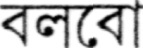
বলবো
